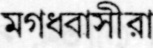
মগধবাসীরা
